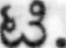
ಟಿ.
